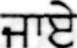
ਜਾਏ
